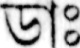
ডাঃ
